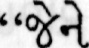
"જેને
